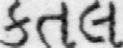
કતલ
